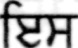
ਇਸ
